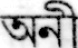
অনী
